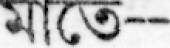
মাতে-
